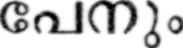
പേനും
